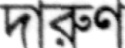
দারুণ
